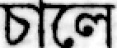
চালে
